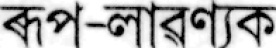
ৰূপ-লাৱণ্যক
